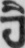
ਹੈ
